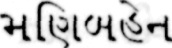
મણિબહેન
